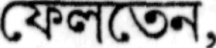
ফেলতেন,
